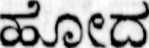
ಹೋದ
